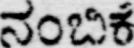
ನಂಬಿಕೆ
